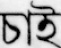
চাই
